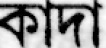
কাদা
